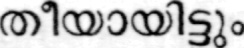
തീയായിട്ടും
